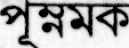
পুম্নমক
